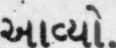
આવ્યો.
